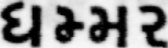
ધમ્મર
